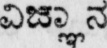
ವಿಜ್ಞಾನ
